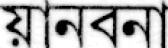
য়ানবনা
